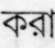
করা
